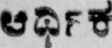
ಆರ್ಥಿಕ
